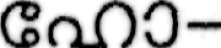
ഹോ-
